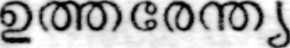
ഉത്തരേന്ത്യ
